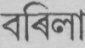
বৰিলা
